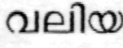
വലിയ
